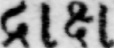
દ્રાક્ષ
